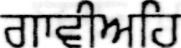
ਗਾਵੀਅਹਿ
